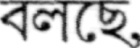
বলছে,
